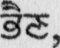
ਭੈਣ,
